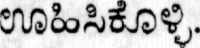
ಊಹಿಸಿಕೊಳ್ಳಿ.
